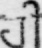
ਹੀ
